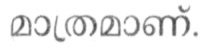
മാത്രമാണ്.
